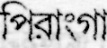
পিরাংগা
